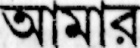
আমার
